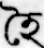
হৈ
